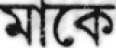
মাকে
